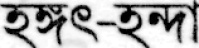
হঙ্গৎ-হন্দা
